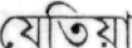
যেতিয়া
